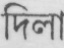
দিলা
